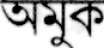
অমুক
